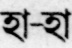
হা-হা
